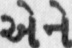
એને
